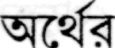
অর্থের
